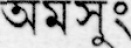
অমসুং
